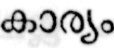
കാര്യം
